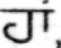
ਹਾਂ,
